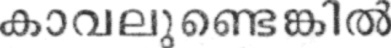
കാവലുണ്ടെങ്കില്‍
